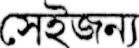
সেইজন্য
